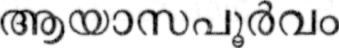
ആയാസപൂര്‍വം
